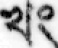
খং
